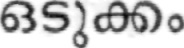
ഒടുക്കം
